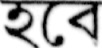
হবে
